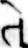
તે
